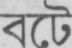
বটে
